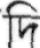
দি
